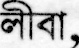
লীবা,
